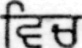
ਵਿਚ
